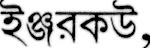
ইঞ্জরকউ,
